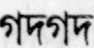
গদগদ
